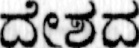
ದೇಶದ
